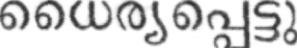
ധൈര്യപ്പെട്ടു
